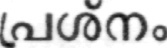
പ്രശ്നം
